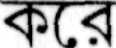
করে
